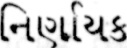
નિર્ણાયક
